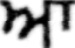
ਆ
